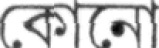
কোনো
